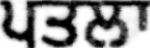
ਪਤਲਾ
